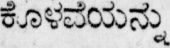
ಕೊಳವೆಯನ್ನು
